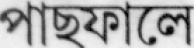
পাছফালে
